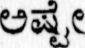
ಅಷ್ಟೇ
